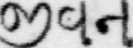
જીવન
